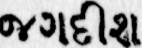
જગદીશ
